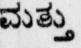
ಮತ್ತು
